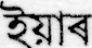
ইয়াৰ
